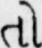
તો
